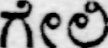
ಗೇಲಿ
